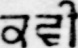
ਕਵੀ
